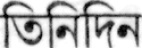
তিনিদিন
